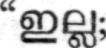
"ഇല്ല;
